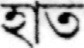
হাত
